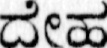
ದೇಹ
